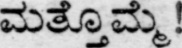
ಮತ್ತೊಮ್ಮೆ!
